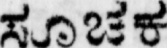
ಸೂಚಕ
